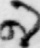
જે
